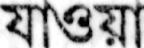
যাওয়া
